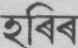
হৰিৰ
